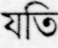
যতি
